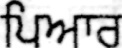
ਪਿਆਰ
